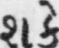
શકે
